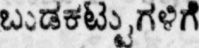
ಬುಡಕಟ್ಟುಗಳಿಗೆ
